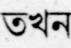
তখন
